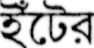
ইঁটের
